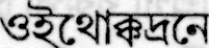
ওইথোক্কদ্রনে
